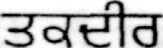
ਤਕਦੀਰ
